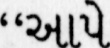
"આપે
